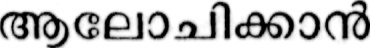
ആലോചിക്കാന്‍
